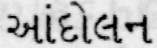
આંદોલન
